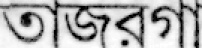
তাজরগা
